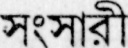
সংসারী
